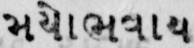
મયોભવાય
